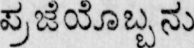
ಪ್ರಜೆಯೊಬ್ಬನು
